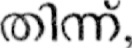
തിന്ന്,
